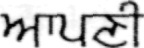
ਆਪਣੀ
